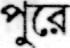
পুরে
